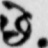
છે.
